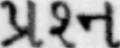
પ્રશ્ન
